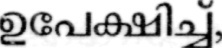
ഉപേക്ഷിച്ച്,
